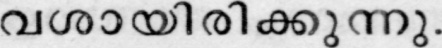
വശായിരിക്കുന്നു.
